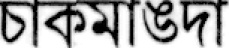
চাকমাঙদা
